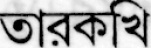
তারকখি
